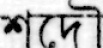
শদৌ
